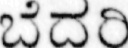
ಬೆದರಿ
